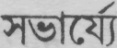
সভাৰ্য্যে
